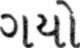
ગયો
